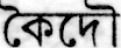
কৈদৌ
